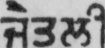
ਜੈਤਲੀ
